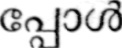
പ്പോള്‍
